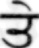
ਤੇ
